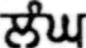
ਲੰਘ
